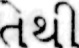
તેથી
